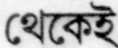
থেকেই
